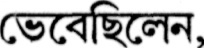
ভেবেছিলেন,
